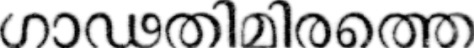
ഗാഢതിമിരത്തെ
